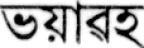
ভয়াৱহ
